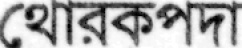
থোরকপদা
